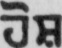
ਹੋਸ਼
